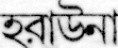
হরাউনা
